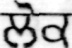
ਲੋਕ
